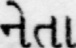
નેતા
